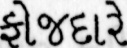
ફોજદારે
